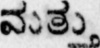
ಮತ್ತು
